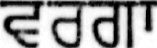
ਵਰਗਾ
